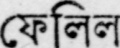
ফেলিল
